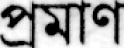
প্রমাণ
